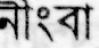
নীংবা
